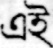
এই
